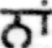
ਨਾਂ
